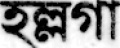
হল্লগা
